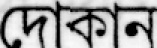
দোকান
